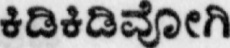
ಕಿಡಿಕಿಡಿವೋಗಿ
